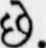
છે.
